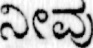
ನೀವು
